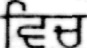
ਵਿਚ
